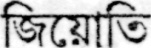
জিয়োতি
